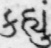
કહ્યું
